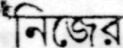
‘নিজের
